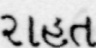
રાહત
